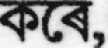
কৰে,
